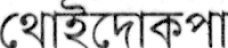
থোইদোকপা
